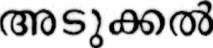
അടുക്കല്‍
